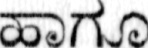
ಹಾಗೂ
